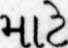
માટે
